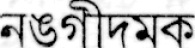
নঙগীদমক
